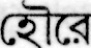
হৌরে
